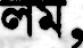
লম,
